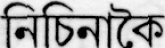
নিচিনাকৈ
